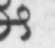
ಈ
